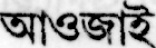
আওজাই
